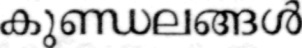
കുണ്ഡലങ്ങള്‍
